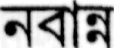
নবান্ন
